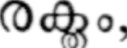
രക്തം,
